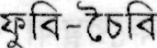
ফুবি-চৈবি
